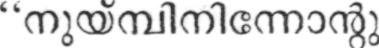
"നുയ്മ്പിനിന്നോന്റു
